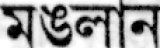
মঙলান
